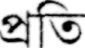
প্রতি
